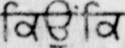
ਕਿਉਂਕਿ
